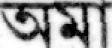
অমা
